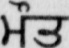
ਮੌਤ
